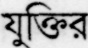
যুক্তির
